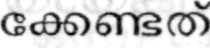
ക്കേണ്ടത്
